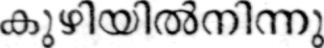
കുഴിയില്‍നിന്നു
